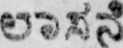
ಲಾಸನೆ
